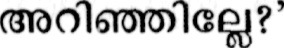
അറിഞ്ഞില്ലേ?’
